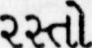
રસ્તો
